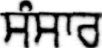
ਸੰਸਾਰ
